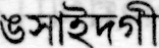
ঙসাইদগী
